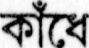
কাঁধে
